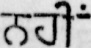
ਨਹੀਂ
